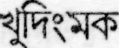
খুদিংমক
